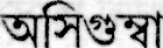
অসিগুম্বা
